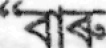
"বাৰু
